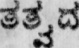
ತತ್ವದ
